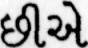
છીએ
